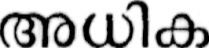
അധിക
